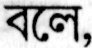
বলে,
